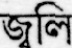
জ্বলি
